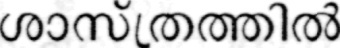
ശാസ്ത്രത്തില്‍
